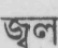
জ্বল
